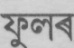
ফুলৰ
